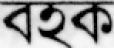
বহক
